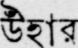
উঁহার
